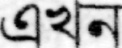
এখন
